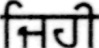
ਜਿਹੀ
